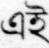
এই
